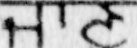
ਜਾਣ
